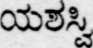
ಯಶಸ್ವಿ
